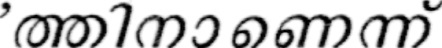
'ത്തിനാണെന്ന്
